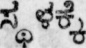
ಸ್ಥಳಕ್ಕೆ
